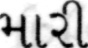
મારી
